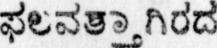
ಫಲವತ್ತಾಗಿರದ
